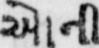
ઓની
